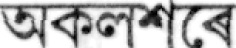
অকলশৰে
